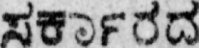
ಸರ್ಕಾರದ
